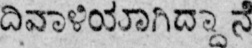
ದಿವಾಳಿಯಾಗಿದ್ದಾನೆ
